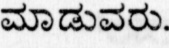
ಮಾಡುವರು.
